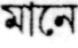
মানে
